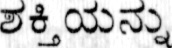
ಶಕ್ತಿಯನ್ನು
